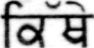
ਕਿੱਥੇ
